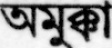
অমুক্কা
